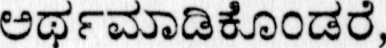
ಅರ್ಥಮಾಡಿಕೊಂಡರೆ,
